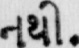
નથી.
